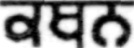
ਕਥਨ
